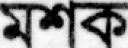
মশক
